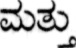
ಮತ್ತು
